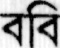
ববি
